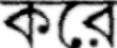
করে
